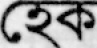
হেক
